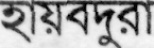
হায়বদুরা
